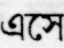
এসে
